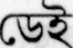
ডেই
